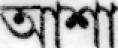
আশা
